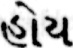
હોય
